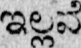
ಇಲ್ಲವೆ
